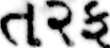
તરફ
